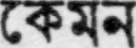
কেমন
